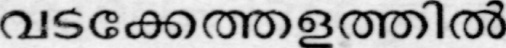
വടക്കേത്തളത്തില്‍
